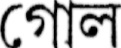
গোল
